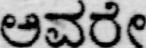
ಅವರೇ
